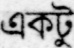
একটু
